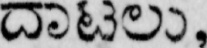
ದಾಟಲು,
